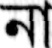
না
